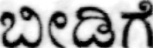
ಬೀಡಿಗೆ
